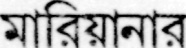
মারিয়ানার
